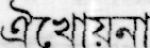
ঐখোয়না
